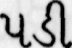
પડી
